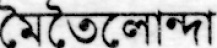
মৈতৈলোন্দা
